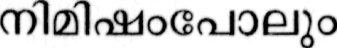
നിമിഷംപോലും
